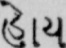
હોય
